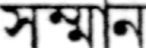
সম্মান
